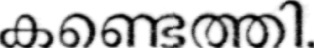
കണ്ടെത്തി.
